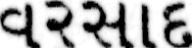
વરસાદ
